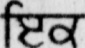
ਇਕ
